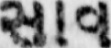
સાવ
